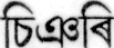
চিঞৰি
